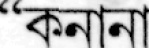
“কনানা
